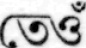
তেওঁ
